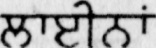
ਲਾਈਨਾਂ
